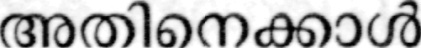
അതിനെക്കാള്‍
